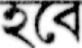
হবে
